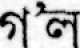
গ'ল
